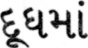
દૂધમાં
